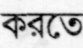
করতে
